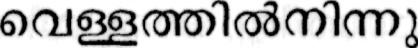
വെള്ളത്തില്‍നിന്നു
